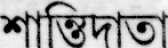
শান্তিদাতা
